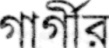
গার্গীর
